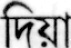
দিয়া
